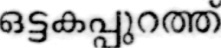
ഒട്ടകപ്പുറത്ത്
